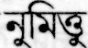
নুনিত্তু
